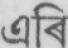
এৰি
